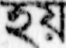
হয়
